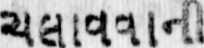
ચલાવવાની
